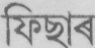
ফিছাৰ
